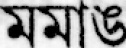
মমাঙ
